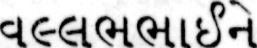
વલ્લભભાઈને
